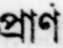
প্রাণ
